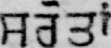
ਸਰੋਤਾਂ
